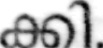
ക്കി.
